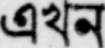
এখন
